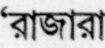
‘রাজারা
